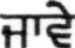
ਜਾਵੇ
